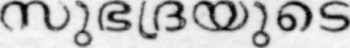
സുഭദ്രയുടെ
